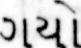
ગયો
